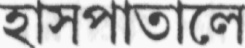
হাসপাতালে
